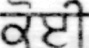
ਕੋਈ
